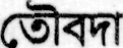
তৌবদা
